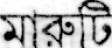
মারুটি
